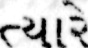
ત્યારે
